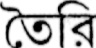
তৈরি
